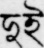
দুই
